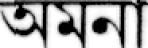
অমনা
